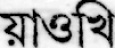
য়াওখি
